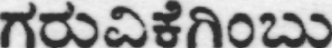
ಗರುವಿಕೆಗಿಂಬು
